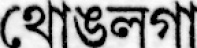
থোঙলগা
